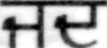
ਜਦ
